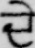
ਦੇ
